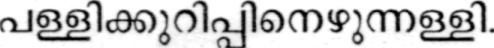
പള്ളിക്കുറിപ്പിനെഴുന്നള്ളി.
